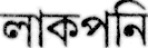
লাকপনি
